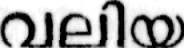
വലിയ
